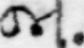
જા.
